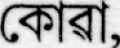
কোৱা,
